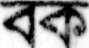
বক
